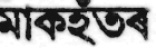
মাকহঁতৰ
